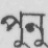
পুনু
